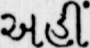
અહીં
